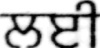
ਲਈ
